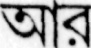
আর
